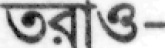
তরাও-
